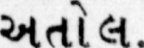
અતોલ.
